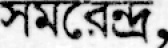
সমরেন্দ্র,
